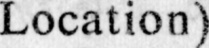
Location)
